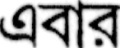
এবার
